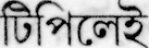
টিপিলেই
